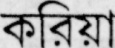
করিয়া
